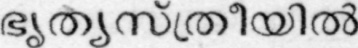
ഭൃത്യസ്ത്രീയില്‍
